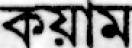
কয়াম
